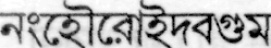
নংহৌরোইদবগুম
